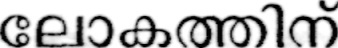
ലോകത്തിന്
